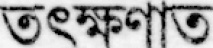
তৎক্ষণাত
